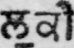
ਲੁਕੀ
